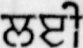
ਲਈ
